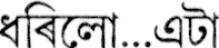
ধৰিলো...এটা
